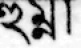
হুম্না
